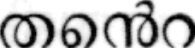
തന്റെ
